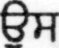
ਉਸ
